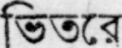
ভিতরে
